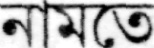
নামতে
